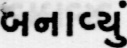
બનાવ્યું
